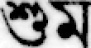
শুম
